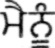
ਮੈਨੂੰ
